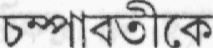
চম্পাবতীকে
